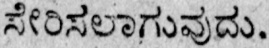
ಸೇರಿಸಲಾಗುವುದು.
